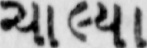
ચાલ્યા
